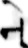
ને
